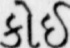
કોઈ
